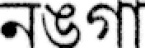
নঙগা
